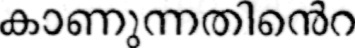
കാണുന്നതിന്റെ
